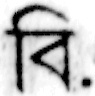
বি.
